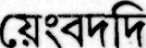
য়েংবদদি
